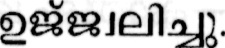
ഉജ്ജ്വലിച്ചു.
